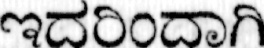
ಇದರಿಂದಾಗಿ
